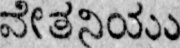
ವೇತನಿಯು
